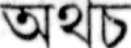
অথচ
